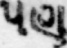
પણ
